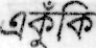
একুঁকি
